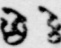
છેકે
